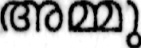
അമ്മു
